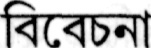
বিবেচনা
